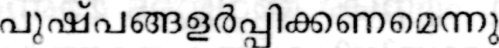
പുഷ്പങ്ങളര്‍പ്പിക്കണമെന്നു
